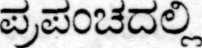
ಪ್ರಪಂಚದಲ್ಲಿ
